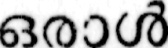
ഒരാള്‍
